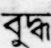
বুদ্ধ
